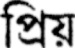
প্রিয়
